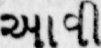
આવી
